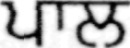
ਪਾਲ
